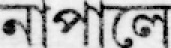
নাপালে
